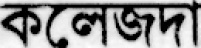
কলেজদা
